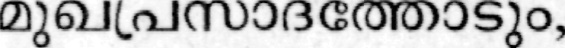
മുഖപ്രസാദത്തോടും,
